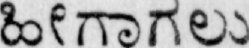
ಹೀಗಾಗಲು
